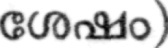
ശേഷം)
